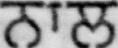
ਨਾਲ
